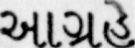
આગ્રહ
